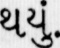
થયું.
